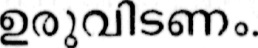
ഉരുവിടണം.
